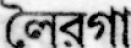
লৈরগা
